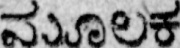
ಮೂಲಕ
